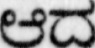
ಆದ
